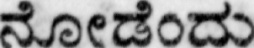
ನೋಡೆಂದು
